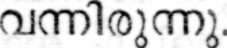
വന്നിരുന്നു.
